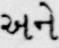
અને
